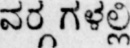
ವರ್‍ಗಗಳಲ್ಲಿ
